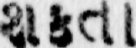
શકતા
